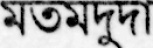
মতমদুদা
